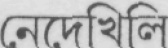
নেদেখিলি
